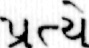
પ્રત્યે
